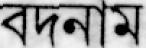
বদনাম
